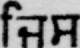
ਜਿਸ
